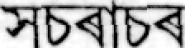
সচৰাচৰ
